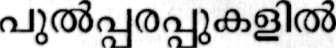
പുല്‍പ്പരപ്പുകളില്‍
